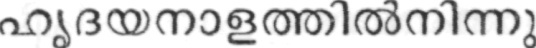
ഹൃദയനാളത്തില്‍നിന്നു
